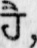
ਹੈ,
